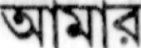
আমার
